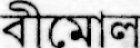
বীমোল
